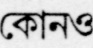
কোনও
